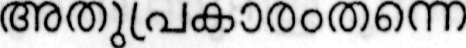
അതുപ്രകാരംതന്നെ
